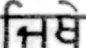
ਜਿਥੇ
